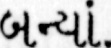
બન્યાં.
